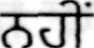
ਨਹੀਂ
